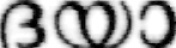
ദയാ
